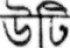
উটি
